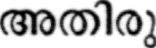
അതിരു
